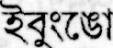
ইবুংঙো
